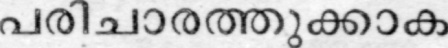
പരിചാരത്തുക്കാക
